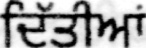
ਦਿੱਤੀਆਂ
